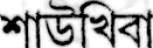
শাউখিবা
